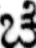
ಚೆ
